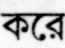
করে
